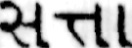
સત્તા
